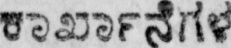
ಕಾರ್ಖಾನೆಗಳ
